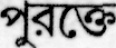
পুরক্তে
